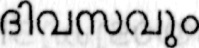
ദിവസവും
